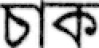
চাক
